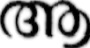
ആ
